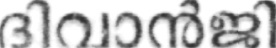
ദിവാന്‍ജി
